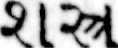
શસ્ત્ર
